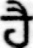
ਹੈ
